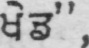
ਖੇਡ'',
